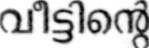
വീട്ടിന്റെ
